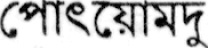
পোৎয়োমদু
